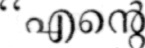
"എന്റെ
